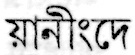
য়ানীংদে
